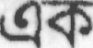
এক
